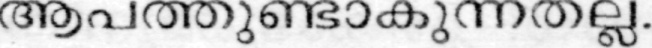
ആപത്തുണ്ടാകുന്നതല്ല.
